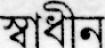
স্বাধীন
